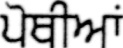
ਪੋਥੀਆਂ
